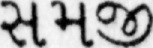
સમજી
